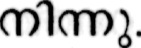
നിന്നു.
